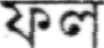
ফল
